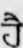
ਹੈ
